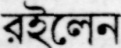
রইলেন
